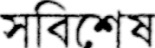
সবিশেষ
